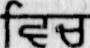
ਵਿਚ
